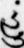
હું
